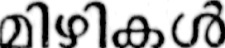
മിഴികള്‍
